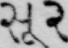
સૂર
